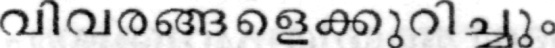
വിവരങ്ങളെക്കുറിച്ചും
